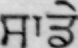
ਸਾਡੇ
